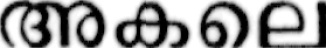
അകലെ
